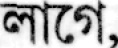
লাগে,
